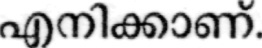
എനിക്കാണ്.
